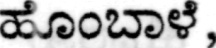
ಹೊಂಬಾಳೆ,
